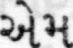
એમ
